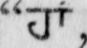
''ਹਾਂ,
